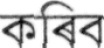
কৰিব
